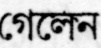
গেলেন
